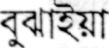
বুঝাইয়া
